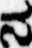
ನ
